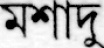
মশাদু
